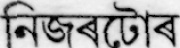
নিজৰটোৰ
